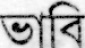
ভাবি
